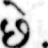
છે.
